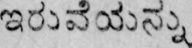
ಇರುವೆಯನ್ನು
